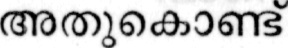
അതുകൊണ്ട്
